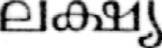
ലക്ഷ്യ
